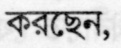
করছেন,
